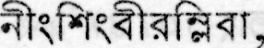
নীংশিংবীরম্লিবা
